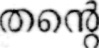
തന്റെ
